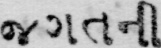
જગતની
